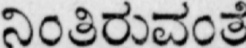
ನಿಂತಿರುವಂತೆ
